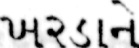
ખરડાને
